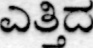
ಎತ್ತಿದ
